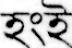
হংই
